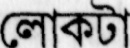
লোকটা
